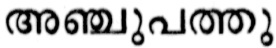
അഞ്ചുപത്തു
